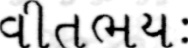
વીતભયઃ
